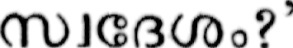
സ്വദേശം?’
